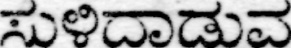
ಸುಳಿದಾಡುವ
